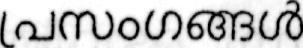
പ്രസംഗങ്ങള്‍
